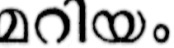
മറിയം
